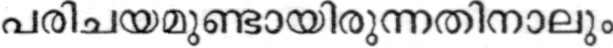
പരിചയമുണ്ടായിരുന്നതിനാലും
